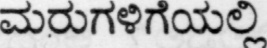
ಮರುಗಳಿಗೆಯಲ್ಲಿ
